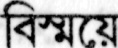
বিস্ময়ে
